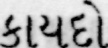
કાયદો
